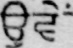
ਉਵੇਂ
